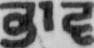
ਭਾਵ
